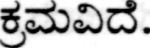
ಕ್ರಮವಿದೆ.
